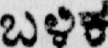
ಬಳಿಕ
